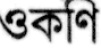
ওকণি
